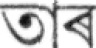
তাৰ
